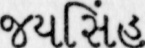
જયસિંહ
